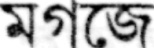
মগজে
